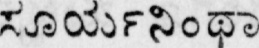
ಸೂರ್ಯನಿಂಥಾ
